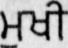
ਮੁਖੀ
